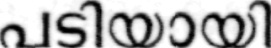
പടിയായി
